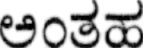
ಅಂತಹ
